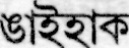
ঙাইহাক
